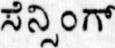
ಸೆನ್ಸಿಂಗ್
